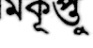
মিকূপ্তু
